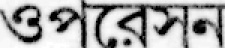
ওপরেসন
